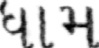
ધામ
